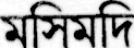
মসিমদি
